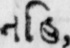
નહિ.
